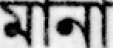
মানা
